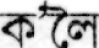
ক'লৈ
